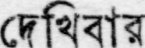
দেখিবার
